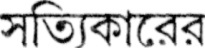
সত্যিকারের
